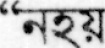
"নহয়
